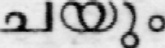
ചയും
